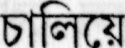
চালিয়ে
